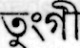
তুংগী
